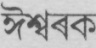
ঈশ্বৰক
